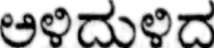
ಅಳಿದುಳಿದ
